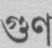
গুণ
